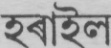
হৰাইল
